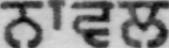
ਨਾਵਲ
